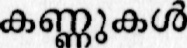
കണ്ണുകള്‍
